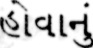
હોવાનું
